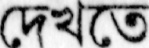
দেখতে
